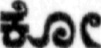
ಕೋ
